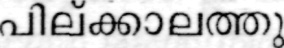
പില്ക്കാലത്തു
